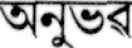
অনুভৱ
